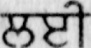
ਲਈ
